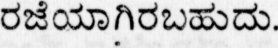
ರಜೆಯಾಗಿರಬಹುದು.
